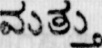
ಮತ್ತು
